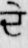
ਦੇ
